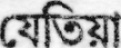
যেতিয়া
